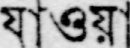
যাওয়া
